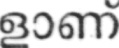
ളാണ്
